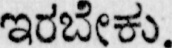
ಇರಬೇಕು.
